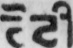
ਰੋਟੀ
